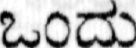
ಒಂದು
